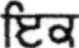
ਇਕ
